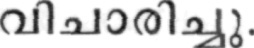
വിചാരിച്ചു.
